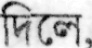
দিলে,
